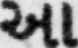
આ
